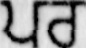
ਪਰ
